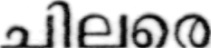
ചിലരെ
